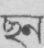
ছন
